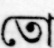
তো
